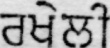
ਰਖੇਲੀ
